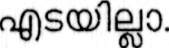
എടയില്ലാ.
